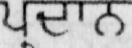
ਪ੍ਰਦਾਨ
